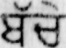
ਬੱਚੇ
